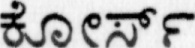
ಕೋರ್ಸ್
